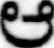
ಆ
